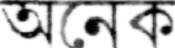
অনেক
